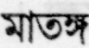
মাতঙ্গ
